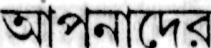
আপনাদের
